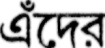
এঁদের
